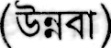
(উন্নবা)
